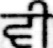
ਵੀ
